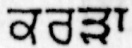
ਕਰੜਾ
